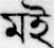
মই
